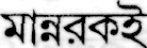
মান্নরকই
